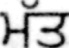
ਮੱਤ
